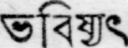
ভবিষ্যৎ
